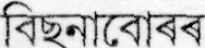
বিছনাবোৰৰ
